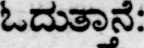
ಓದುತ್ತಾನೆ:
